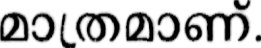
മാത്രമാണ്.
